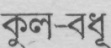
কুল-বধূ
